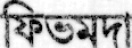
ফিভমদা
